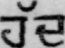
ਹੱਦ
